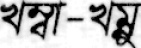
খম্বা-খম্নু
